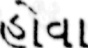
હોવા
